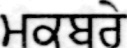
ਮਕਬਰੇ
